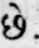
છે.
